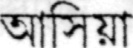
আসিয়া
